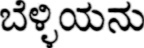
ಬೆಳ್ಳಿಯನು
